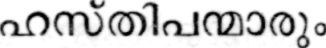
ഹസ്തിപന്മാരും
